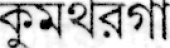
কুমথরগা
